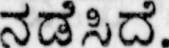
ನಡೆಸಿದೆ.
